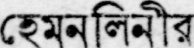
হেমনলিনীর
